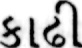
કાઢી
